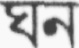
ঘন
